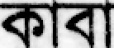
কাবা
